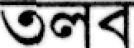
তলব
